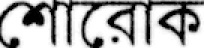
শোরোক
